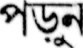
পড়ুন
